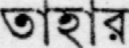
তাহার
